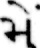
મેં
